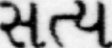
સત્ય
